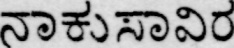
ನಾಕುಸಾವಿರ
